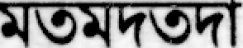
মতমদতদা
